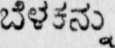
ಬೆಳಕನ್ನು
